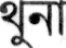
থুনা
